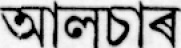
আলচাৰ
